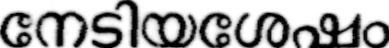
നേടിയശേഷം
